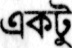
একটু
